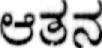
ಆತನ
